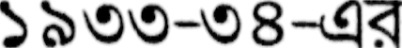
১৯৩৩-৩৪-এর
